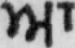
ਆ
